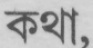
কথা,
